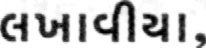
લખાવીયા,
